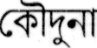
কৌদুনা
